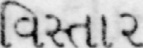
વિસ્તાર
